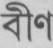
বীণ
